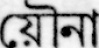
য়ৌনা
